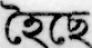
হৈছে
